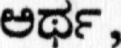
ಅರ್ಥ,
